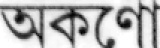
অকণো
